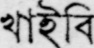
খাইবি
